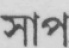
সাপ
